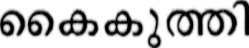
കൈകുത്തി
